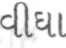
વીઘા
